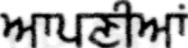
ਆਪਣੀਆਂ
